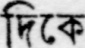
দিকে
